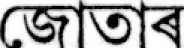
জোতাৰ
